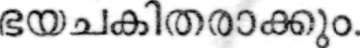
ഭയചകിതരാക്കും.
